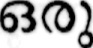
ഒരു
